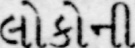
લોકોની
